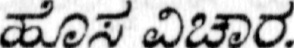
ಹೊಸವಿಚಾರ.
